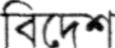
বিদেশ
